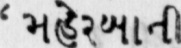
'મહેરબાની
